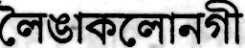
লৈঙাকলোনগী
